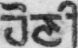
ਹੋਣੀ
